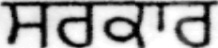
ਸਰਕਾਰ
